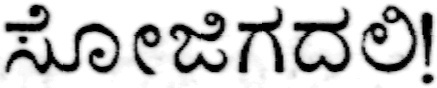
ಸೋಜಿಗದಲಿ!
